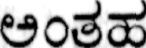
ಅಂತಹ
